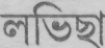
লভিছা
